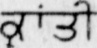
ਕ੍ਰਾਂਤੀ
